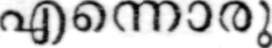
എന്നൊരു
